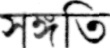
সঙ্গতি
